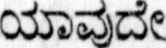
ಯಾವುದೇ
